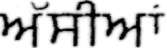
ਅੱਸੀਆਂ
